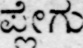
ಪ್ಲೇಗು
